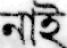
নাই
